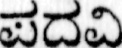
ಪದವಿ
